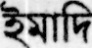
ইমাদি
